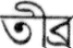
তীব্ৰ
